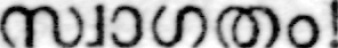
സ്വാഗതം!
